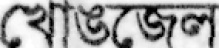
খোঙজেল
